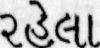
રહેલા
